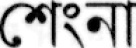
শেংনা
